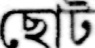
ছোট
